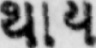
થાય
